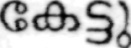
കേട്ടു
